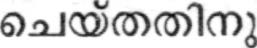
ചെയ്തതിനു
